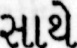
સાથે
